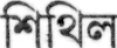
শিথিল
